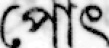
পোৎ
